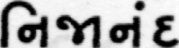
નિજાનંદ
